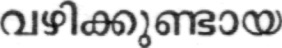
വഴിക്കുണ്ടായ
